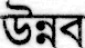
উন্নব
